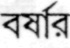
বর্ষার
